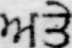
ਅਤੇ
